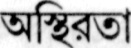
অস্থিরতা
